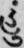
હું
